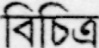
বিচিত্র
